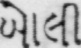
બોલી
